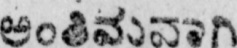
ಅಂತಿಮವಾಗಿ
